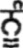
ਨੂੰ
